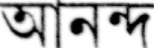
আনন্দ
